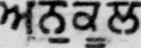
ਅਨੁਕੂਲ
